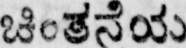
ಚಿಂತನೆಯ
